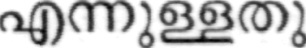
എന്നുള്ളതു
